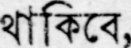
থাকিবে,
